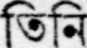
তিনি
